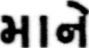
માને
